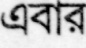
এবার
